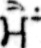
ਮੈਂ
